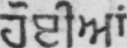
ਹੋਈਆਂ
